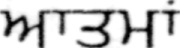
ਆਤਮਾਂ
